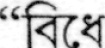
"বিধে
